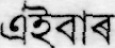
এইবাৰ
